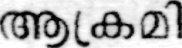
ആക്രമി
